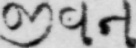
જીવન
